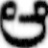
ಆ
